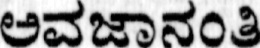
ಅವಜಾನಂತಿ
